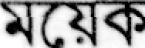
ময়েক
